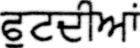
ਫੁਟਦੀਆਂ
